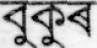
বুকুৰ
